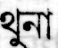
থুনা
